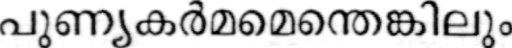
പുണ്യകര്‍മമെന്തെങ്കിലും
